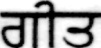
ਗੀਤ
